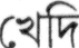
খেদি
